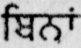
ਬਿਨਾਂ
